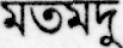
মতমদু
